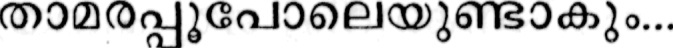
താമരപ്പൂപോലെയുണ്ടാകും...
